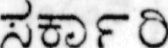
ಸರ್ಕಾರಿ
